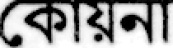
কোয়না
